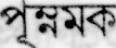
পূম্নমক
